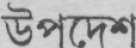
উপদেশ
